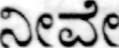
ನೀವೇ
